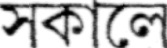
সকালে
